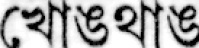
খোঙথাঙ
